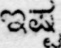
ಇಷ್ಟ
